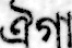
ঐগা
